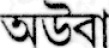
অউবা
